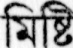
মিষ্টি
